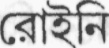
রোইনি
